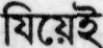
যিয়েই
